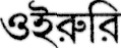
ওইরুরি
